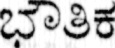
ಭೌತಿಕ
